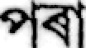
পৰা
